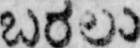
ಬರಲು
